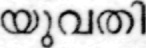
യുവതി
